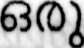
ഒരു
